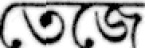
তেজে
